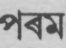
পৰম
